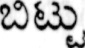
ಬಿಟ್ಟು
